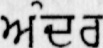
ਅੰਦਰ
